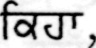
ਕਿਹਾ,
